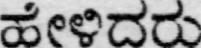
ಹೇಳಿದರು
